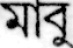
মাবু
